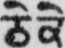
ਠੇਕੇ
